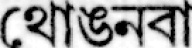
থোঙনবা
